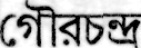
গৌরচন্দ্র
